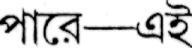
পারে-এই
